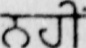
ਨਹੀਂ
